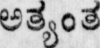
ಅತ್ಯಂತ
